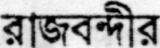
রাজবন্দীর
